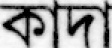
কাদা
